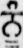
ਨੂੰ
